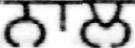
ਨਾਲ
